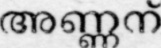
അണ്ണന്
